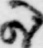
જે
